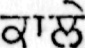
ਕਾਲੇ
